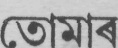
তোমাৰ
